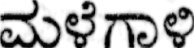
ಮಳೆಗಾಳಿ
